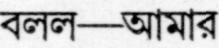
বলল–আমার
